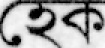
হেক
